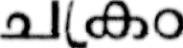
ചക്രം
